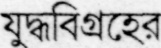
যুদ্ধবিগ্রহের
